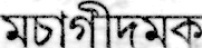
মচাগীদমক
